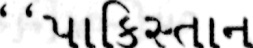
"પાકિસ્તાન
